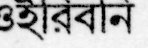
ওইরিবনি
